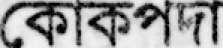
কোকপদা
